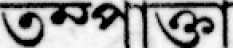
তম্পাক্তা
